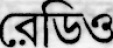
রেডিও
